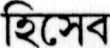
হিসেব
